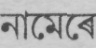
নামেৰে
